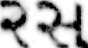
રસ
